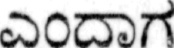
ಎಂದಾಗ
